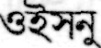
ওইসনু
